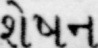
શેષન
